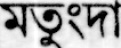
মতুংদা
